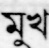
মুখ
